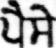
ਪੈਸੇ
